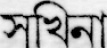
সখিনা
